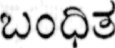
ಬಂಧಿತ
